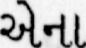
એના
